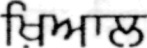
ਖ਼ਿਆਲ
